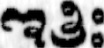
ಇತಿಃ
